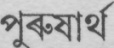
পুৰুষাৰ্থ
